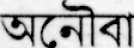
অনৌবা
